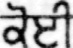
ਕੋਈ
